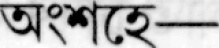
অংশহে-
